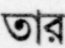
তার
